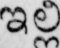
ಇಲ್ಲಿ
